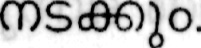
നടക്കും.
